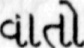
વાતો
